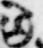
છે.
